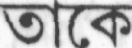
তাকে
